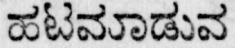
ಹಟಮಾಡುವ
